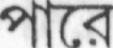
পারে
